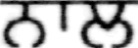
ਨਾਲ
